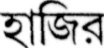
হাজির
